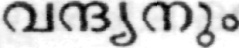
വന്ദ്യനും
